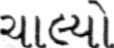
ચાલ્યો
